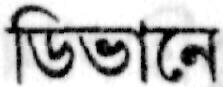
ডিভানে
